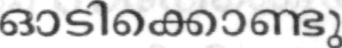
ഓടിക്കൊണ്ടു
